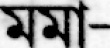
মমা-
